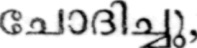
ചോദിച്ചു,
